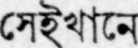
সেইখানে
